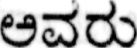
ಅವರು
